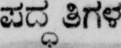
ಪದ್ಧತಿಗಳ
